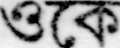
ওকে
